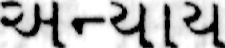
અન્યાય
